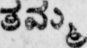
ತಮ್ಮ
